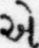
એ
